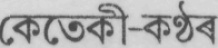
কেতেকী-কণ্ঠৰ
